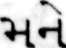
મને
